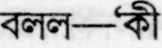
বলল–‘কী
